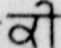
ਕੀ
